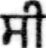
ਸੀ
